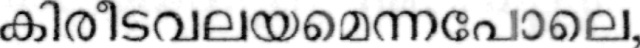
കിരീടവലയമെന്നപോലെ,
